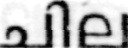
ചില
